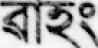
ৱাহং
